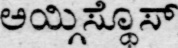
ಅಯ್ಗಿಸ್ಥೊಸ್
